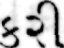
કરી
